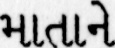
માતાને
